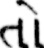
તો
